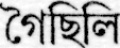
গৈছিলি
